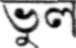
ভুল
